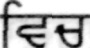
ਵਿਚ
